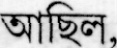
আছিল,
